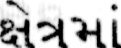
ક્ષેત્રમાં
